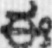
ಈ
